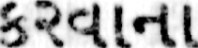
કરવાના
